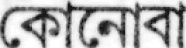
কোনোবা
